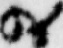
જ
